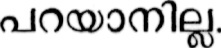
പറയാനില്ല.
